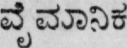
ವೈಮಾನಿಕ
